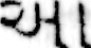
આ
